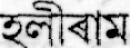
হলীৰাম
